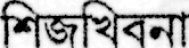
শিজখিবনা
